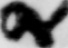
જ
